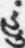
હું
